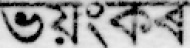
ভয়ংকৰ
